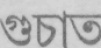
গুচাত
